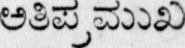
ಅತಿಪ್ರಮುಖ
